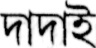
দাদাই
